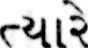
ત્યારે
